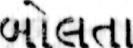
બોલતા
